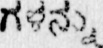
ಗಳನ್ನು
